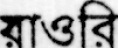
য়াওরি
